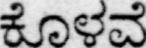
ಕೊಳವೆ
